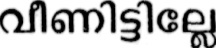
വീണിട്ടില്ലേ
